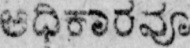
ಅಧಿಕಾರವೂ
